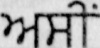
ਅਸੀਂ
